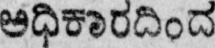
ಅಧಿಕಾರದಿಂದ
